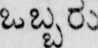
ಒಬ್ಬರು
